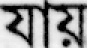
যায়
